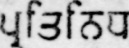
ਪ੍ਰਤਿਨਿਧ
